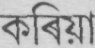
কৰিয়া
